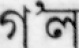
গ'ল
